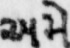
અમે
